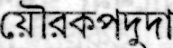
য়ৌরকপদুদা
